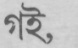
গই,
